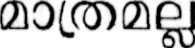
മാത്രമല്ല
